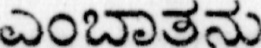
ಎಂಬಾತನು
